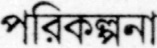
পরিকল্পনা
